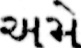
અમે
